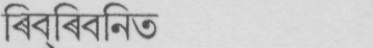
ৰিব্‌ৰিবনিত
